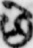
છે
